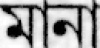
মানা
